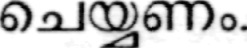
ചെയ്യണം.
